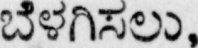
ಬೆಳಗಿಸಲು,
